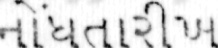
નોંધતારીખ
